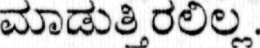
ಮಾಡುತ್ತಿರಲಿಲ್ಲ.
